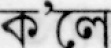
ক'লে
